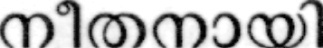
നീതനായി
